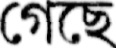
গেছে
